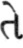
તે
